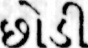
છોડી
